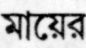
মায়ের
